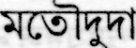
মতৌদুদা
